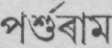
পর্শুৰাম
